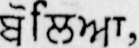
ਬੋਲਿਆ,
